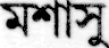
মশাসু
